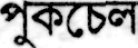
পুকচেল
